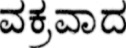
ವಕ್ರವಾದ
